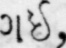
ગઈ,
